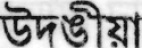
উদঙীয়া
